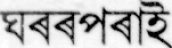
ঘৰৰপৰাই
